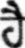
ਹੈ
